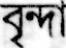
বৃন্দা
